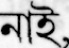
নাই,
